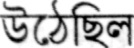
উঠেছিল
